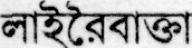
লাইরৈবাক্তা
